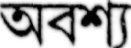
অবশ্য
